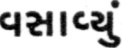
વસાવ્યું
